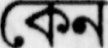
কেন
